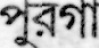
পুরগা
